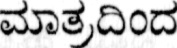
ಮಾತ್ರದಿಂದ
